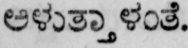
ಅಳುತ್ತಾಳಂತೆ.
